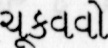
ચૂકવવો
